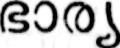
ഭാര്യ
